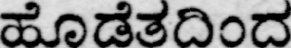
ಹೊಡೆತದಿಂದ
